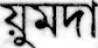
য়ুমদা
